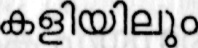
കളിയിലും
